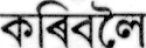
কৰিবলৈ
